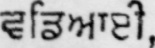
ਵਡਿਆਈ,
